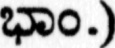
ಭಾಂ.)
